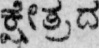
ಕ್ಷೇತ್ರದ
